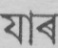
যাৰ
